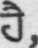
ਹੈ,
